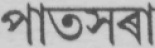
পাতসৰা
